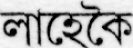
লাহেকৈ
